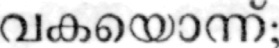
വകയൊന്ന്;
